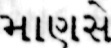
માણસે
